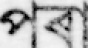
পৰা
